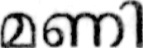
മണി
